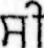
ਸੀ
